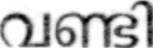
വണ്ടി
